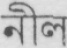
নীল
